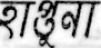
হাপ্তুনা
